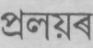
প্রলয়ৰ
